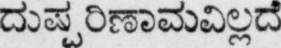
ದುಷ್ಪರಿಣಾಮವಿಲ್ಲದೆ
